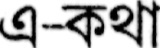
এ-কথা
